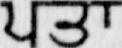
ਪਤਾ
